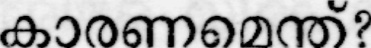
കാരണമെന്ത്?
